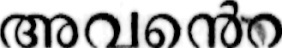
അവന്റെ
